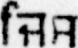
ਜਿਸ
